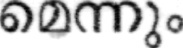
മെന്നും
